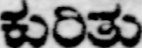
ಕುರಿತು
